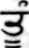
ਤੂੰ
